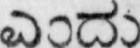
ಎಂದು
